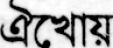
ঐখোয়
